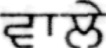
ਵਾਲੇ
